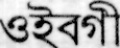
ওইবগী
